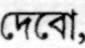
দেবো,
